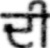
ਦੀ
